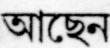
আছেন
